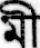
মী
